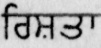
ਰਿਸ਼ਤਾ
